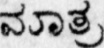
ಮಾತ್ರ
